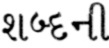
શબ્દની
